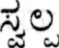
ಸ್ವಲ್ಪ
